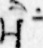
ਮੈਂ
